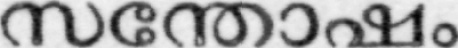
സന്തോഷം
